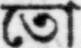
তো
